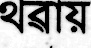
থৱায়
